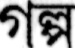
গল্প
